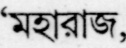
‘মহারাজ,
